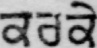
ਕਰਕੇ
